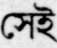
সেই
